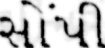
સોંપી
